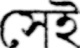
সেই
